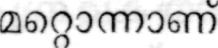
മറ്റൊന്നാണ്
